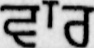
ਵਾਰ
